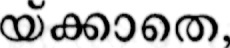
യ്ക്കാതെ,
